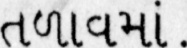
તળાવમાં.
